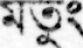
মতুং
